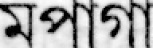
মপাগা
